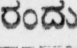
ರಂದು
